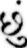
છું
